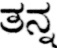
ತನ್ನ
